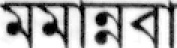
মমান্নবা
